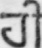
ਹੀ
